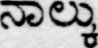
ನಾಲ್ಕು
